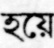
হয়ে
